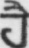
ਹੈ
